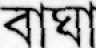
বাঘা
